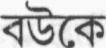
বউকে
